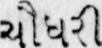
ચૌધરી
